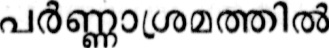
പര്‍ണ്ണാശ്രമത്തില്‍
